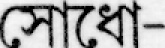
সোধো-
